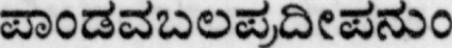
ಪಾಂಡವಬಲಪ್ರದೀಪನುಂ
